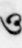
ও
